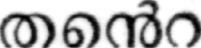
തന്റെ
